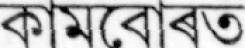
কামবোৰত
